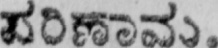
ಪರಿಣಾಮ.
